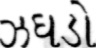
ઝઘડો
